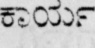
ಕಾರ್ಯ
